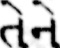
તેને
